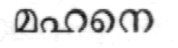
മഹനെ
